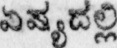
ಏಷ್ಯದಲ್ಲಿ
